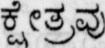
ಕ್ಷೇತ್ರವು
